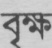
বৃক্ষ
